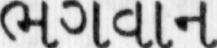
ભગવાન
